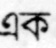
এক
